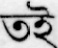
তই
